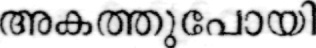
അകത്തുപോയി
